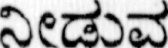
ನೀಡುವ
